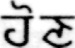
ਹੋਣ
